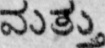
ಮತ್ತು
